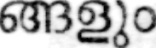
ങ്ങളും
